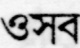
ওসব
